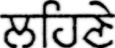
ਲਹਿਣੇ
